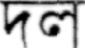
দল
